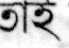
তাই
